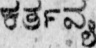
ಕರ್ತವ್ಯ
